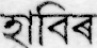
হাবিৰ
